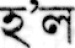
হ'ল
